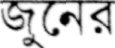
জুনের
